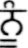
ਨੂੰ
